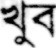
খুব
